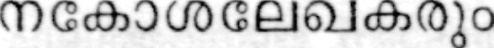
നകോശലേഖകരും
